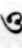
ও
